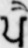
ਪੈ
